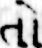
તો
